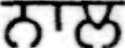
ਨਾਲ
